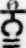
ਨੂੰ
